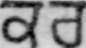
ਕਰ
